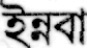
ইন্নবা
